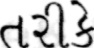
તરીકે
